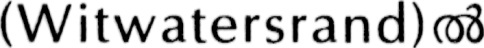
(Witwatersrand)ല്‍
